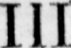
III
